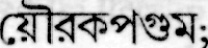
য়ৌরকপগুম;
